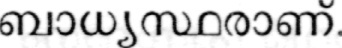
ബാധ്യസ്ഥരാണ്.
